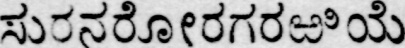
ಸುರನರೋರಗರಱಿಯೆ
